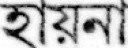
হায়না
